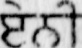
ਏਨੀ
